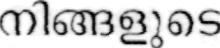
നിങ്ങളുടെ
